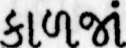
કાળજાં
